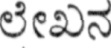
ಲೇಖನ
